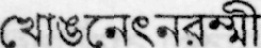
খোঙনেৎনরম্মী
